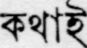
কথাই
